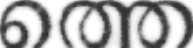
ത്തെ
